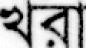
খরা
